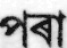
পৰা
